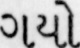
ગયો
